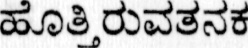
ಹೊತ್ತಿರುವತನಕ
